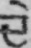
ਦੇ
